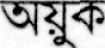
অয়ুক
